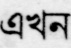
এখন
